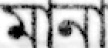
মানা
